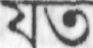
যত
